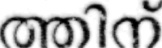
ത്തിന്
